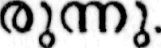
രുന്നു.
